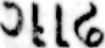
ગાઢ
